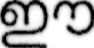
ഈ
